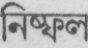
নিষ্ফল
